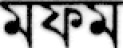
মফম
